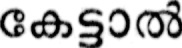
കേട്ടാല്‍
